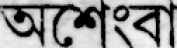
অশেংবা
